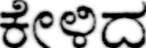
ಕೇಳಿದ
